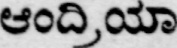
ಆ೦ದ್ರಿಯಾ
